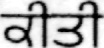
ਕੀਤੀ
